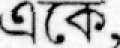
একে,
